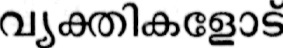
വ്യക്തികളോട്
